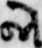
જો
